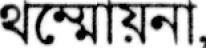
থম্মোয়না,
